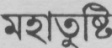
মহাতুষ্টি
